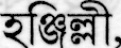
হঞ্জিল্লী,
